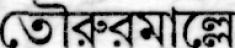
তৌরুরমাল্লে
